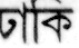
ঢাকি
